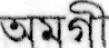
অমগী
